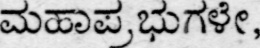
ಮಹಾಪ್ರಭುಗಳೇ,
